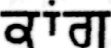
ਕਾਂਗ
